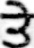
ਤੇ
